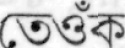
তেওঁক
